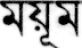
ময়ূম
